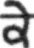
ਕੇ
